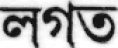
লগত
